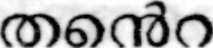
തന്റെ
